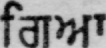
ਗਿਆ
